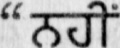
''ਨਹੀਂ
